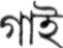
গাই
